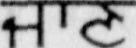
ਜਾਣ
